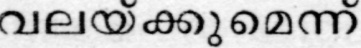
വലയ്ക്കുമെന്ന്
